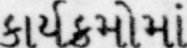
કાર્યક્રમોમાં
